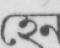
হেন
